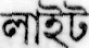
লাইট
